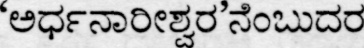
‘ಅರ್ಧನಾರೀಶ್ವರ’ನೆಂಬುದರ
